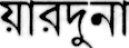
য়ারদুনা
